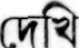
দেখি
